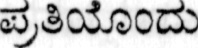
ಪ್ರತಿಯೊಂದು
